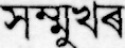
সন্মুখৰ
